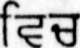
ਵਿਚ
